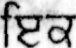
ਇਕ
